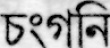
চংগনি
